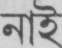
নাই
